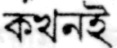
কখনই
